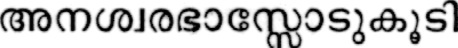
അനശ്വരഭാസ്സോടുകൂടി
